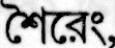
শৈরেং,
